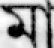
মা
